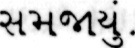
સમજાયું.
